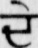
ਦੇ
